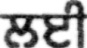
ਲਈ
